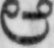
ಆ
